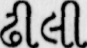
ઢીલી
